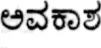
ಅವಕಾಶ
